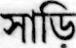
সাড়ি
